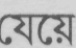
যেয়ে
